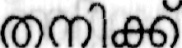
തനിക്ക്
